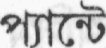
প্যান্টে
